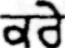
ਕਰੇ
